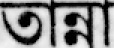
তান্না
